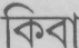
কিবা
